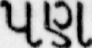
પણ
